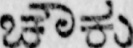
ಚೌಕು
